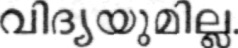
വിദ്യയുമില്ല.
